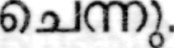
ചെന്നു.
